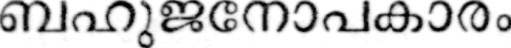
ബഹുജനോപകാരം
